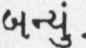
બન્યું.
